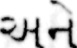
અને
